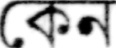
কেন
